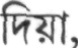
দিয়া,
